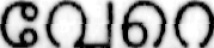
വേറെ
